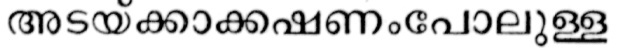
അടയ്ക്കാക്കഷണംപോലുള്ള
